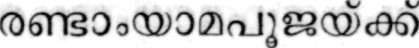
രണ്ടാംയാമപൂജയ്ക്ക്
